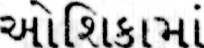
ઓશિકામાં
